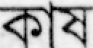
কাষ
